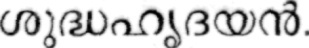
ശുദ്ധഹൃദയന്‍.
